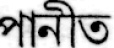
পানীত
